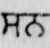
ਸਨ
